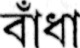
বাঁধা
